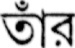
তাঁর
